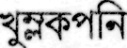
খুম্লকপনি
